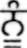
ਨੂੰ
